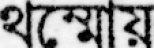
থম্মোয়
